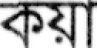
কয়া
